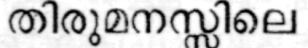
തിരുമനസ്സിലെ
